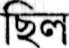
ছিল
